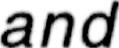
and
